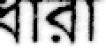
ধারা
